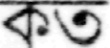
কত
